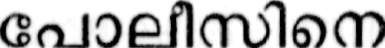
പോലീസിനെ
